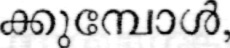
ക്കുമ്പോള്‍,
